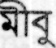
মীবু
